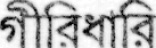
গীরিধারি
